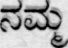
ನಮ್ಮ
